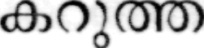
കറുത്ത
